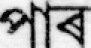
পাৰ
